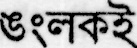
ঙংলকই
